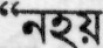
"নহয়
